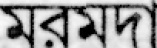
মরমদা
